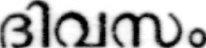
ദിവസം
